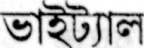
ভাইট্যাল
